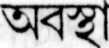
অবস্থা
